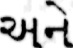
અને
